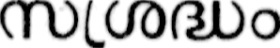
സശ്രദ്ധം
